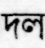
দল
